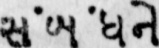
સંબંધને
